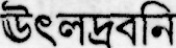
ঊৎলদ্রবনি
